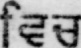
ਵਿਚ
